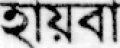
হায়বা
